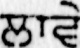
ਲਾਵੇ
